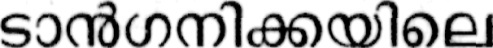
ടാന്‍ഗനിക്കയിലെ
